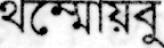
থম্মোয়বু
